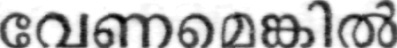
വേണമെങ്കില്‍
